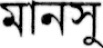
মানসু
